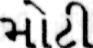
મોટી
